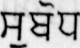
ਸੁਬੋਧ
